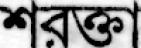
শরক্তা
